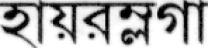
হায়রম্লগা
